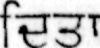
ਦਿਤਾ
